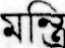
মন্ত্রি
